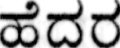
ಹೆದರ
